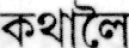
কথালৈ
